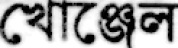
খোঞ্জেল
